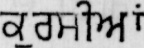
ਕੁਰਸੀਆਂ
